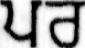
ਪਰ
